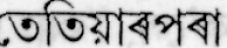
তেতিয়াৰপৰা
